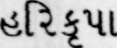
હરિકૃપા
